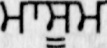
ਮਾਸੂਮ
